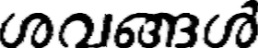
ശവങ്ങള്‍
